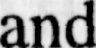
and
